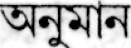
অনুমান
